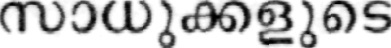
സാധുക്കളുടെ
